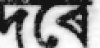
দৰে
